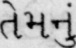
તેમનું
